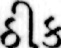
ઠીક
